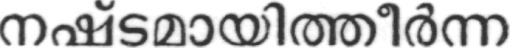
നഷ്ടമായിത്തീര്‍ന്ന
